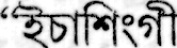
“ইচাশিংগী
